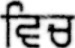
ਵਿਚ
